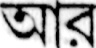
আর
